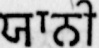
ਯਾਨੀ
